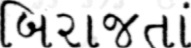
બિરાજતાં
